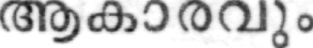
ആകാരവും
